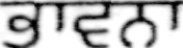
ਭਾਵਨਾ
